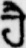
ਹੈ
